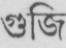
গুজি
